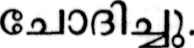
ചോദിച്ചു.
